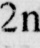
2n
